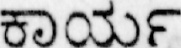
ಕಾರ್ಯ
